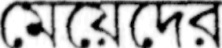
মেয়েদের
